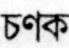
চণক
